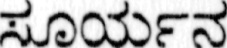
ಸೂರ್ಯನ
